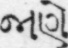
જાણે
